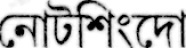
নোটশিংদো
